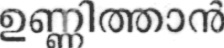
ഉണ്ണിത്താന്‍
